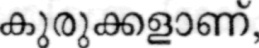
കുരുക്കളാണ്,
